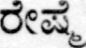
ರೇಷ್ಮೆ
